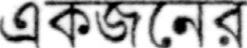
একজনের
